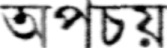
অপচয়
